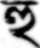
হু
